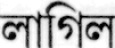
লাগিল
